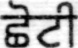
ਛੋਟੀ
